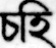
চহি
